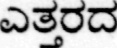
ಎತ್ತರದ
